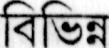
বিভিন্ন
